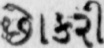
છોકરી
